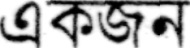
একজন
